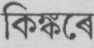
কিঙ্কৰে
